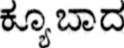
ಕ್ಯೂಬಾದ
